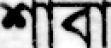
শাবা
